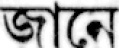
জানে
